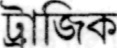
ট্রাজিক
